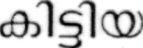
കിട്ടിയ
